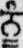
ਨੂੰ
